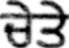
ਚੇਤੇ
